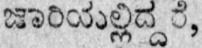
ಜಾರಿಯಲ್ಲಿದ್ದರೆ,
